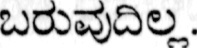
ಬರುವುದಿಲ್ಲ.
